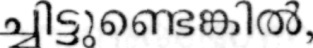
ച്ചിട്ടുണ്ടെങ്കില്‍,
